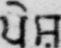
ਪੇਸ਼
